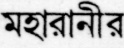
মহারানীর
